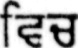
ਵਿਚ
